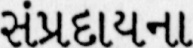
સંપ્રદાયના
